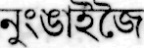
নুংঙাইজৈ
